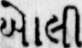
બોલી
